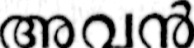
അവന്‍
